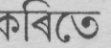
কৰিতে
